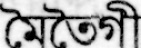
মৈতৈগী
